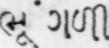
ભૂંગળી
